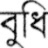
বুধি
